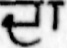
ਦਾ
